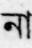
না
